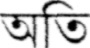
অতি
